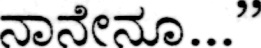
ನಾನೇನೂ.."
